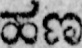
ಹಣ
